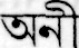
অনী
